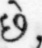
છે,
